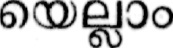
യെല്ലാം
